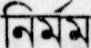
নির্মম
